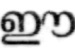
ഈ
